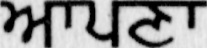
ਆਪਣਾ
